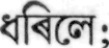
ধৰিলে;
